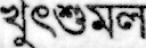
খুৎশুমল
